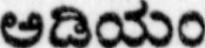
ಅಡಿಯಂ
